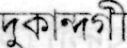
দুকান্দগী
